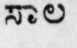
ಸಾಲ
